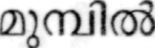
മുമ്പില്‍
